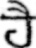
ਹੈ
